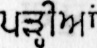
ਪੜ੍ਹੀਆਂ
